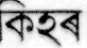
কিহৰ
